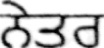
ਨੇਤਰ
